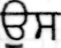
ਉਸ
